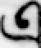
এ
